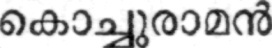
കൊച്ചുരാമന്‍
